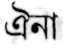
ঐনা
